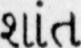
શાંત
